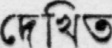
দেখিত
